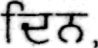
ਦਿਨ,
